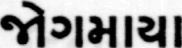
જોગમાયા
